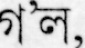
গ'ল,
